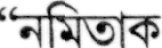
"নমিতাক
